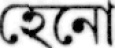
হেনো
